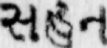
સહન
